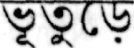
ভূতুড়ে
